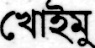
খোইমু
